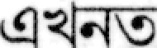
এখনত
